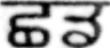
ਛਡ
